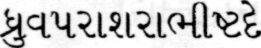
ધ્રુવપરાશરાભીષ્ટદે
